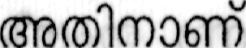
അതിനാണ്
